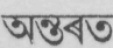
অন্তৰত
